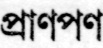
প্রাণপণ
